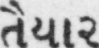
તૈયાર
